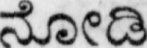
ನೋಡಿ
